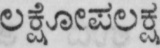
ಲಕ್ಷೋಪಲಕ್ಷ
